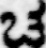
ಚ
